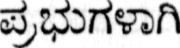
ಪ್ರಭುಗಳಾಗಿ
